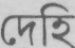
দেহি
